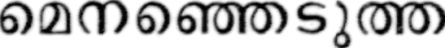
മെനഞ്ഞെടുത്ത
